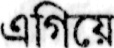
এগিয়ে
